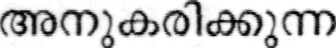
അനുകരിക്കുന്ന
